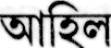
আহিল
